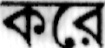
করে
